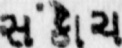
સંકોચ
